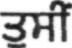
ਤੁਸੀਂ
